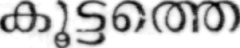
കൂട്ടത്തെ
